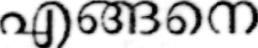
എങ്ങനെ
